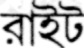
রাইট
